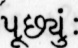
પૂછ્યું:
